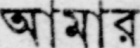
আমার
